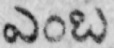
ಎಂಬ
